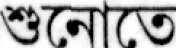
শুনোতে
